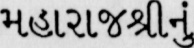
મહારાજશ્રીનું
